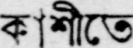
কাশীতে
